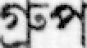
গ্রুপ
